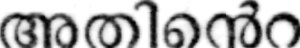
അതിന്റെ
